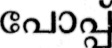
പോപ്പ്
